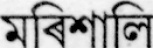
মৰিশালি
